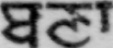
ਬਣਾ
